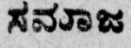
ಸಮಾಜ
